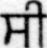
ਸੀ
